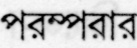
পরম্পরার
